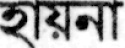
হায়না
